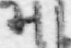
મા
